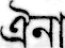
ঐনা
